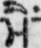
ਮੈਂ
